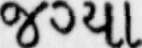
જગ્યા
